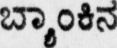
ಬ್ಯಾಂಕಿನ
